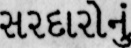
સરદારોનું
